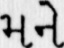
મને
